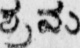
ಶ್ರಮ
